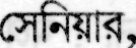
সেনিয়ার,
